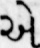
એ
